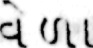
વેળા
